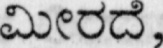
ಮೀರದೆ,
